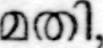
മതി,
